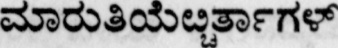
ಮಾರುತಿಯೆೞ್ಚರ್ತಾಗಳ್
